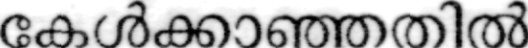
കേള്‍ക്കാഞ്ഞതില്‍
